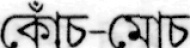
কোঁচ-মোচ
